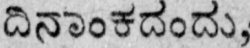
ದಿನಾಂಕದಂದು,
